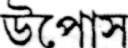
উপোস
